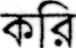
করি
